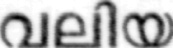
വലിയ
